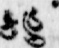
કહું
